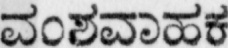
ವಂಶವಾಹಕ
